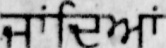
ਜਾਦਿਆਂ
